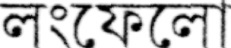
লংফেলো
